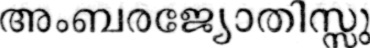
അംബരജ്യോതിസ്സു
